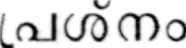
പ്രശ്നം
